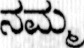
ನಮ್ಮ
